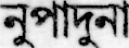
নুপাদুনা
